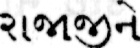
રાજાજીને
